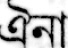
ঐনা
